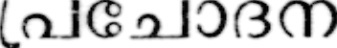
പ്രചോദന
